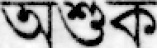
অশুক
